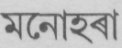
মনোহৰা
